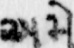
અમે
